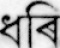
ধৰি
